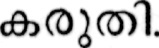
കരുതി.
